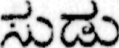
ಸುಡು
